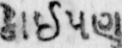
કોઈપણ
